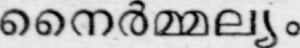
നൈര്‍മ്മല്യം
